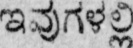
ಇವುಗಳಲ್ಲಿ
